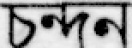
চন্দন
